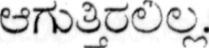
ಆಗುತ್ತಿರಲಿಲ್ಲ.
